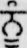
ਨੂੰ
